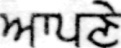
ਆਪਣੇ
